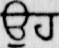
ਉਹ
